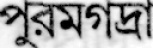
পুরমগদ্রা
